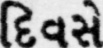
દિવસે
